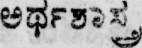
ಅರ್ಥಶಾಸ್ತ್ರ
